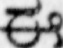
ಈ
